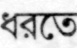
ধরতে
